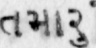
તમારું
